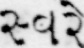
સ્વરે
